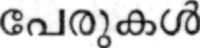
പേരുകള്‍
